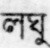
লঘু
